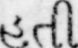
હતી
